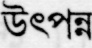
উত্পন্ন
